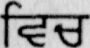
ਵਿਚ
